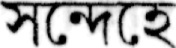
সন্দেহে
